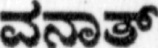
ವನಾತ್
